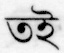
তই
